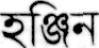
হঞ্জিন
